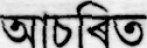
আচৰিত
